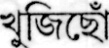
খুজিছোঁ
